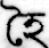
হৈ
